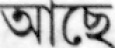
আছে
